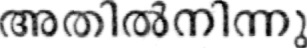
അതില്‍നിന്നു
